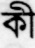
কী
